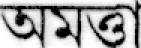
অমত্তা
